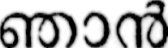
ഞാന്‍
